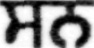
ਸਨ
